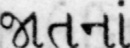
જાતનાં
